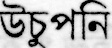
উচুপনি
